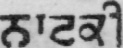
ਨਾਟਕੀ
